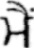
ਮੈਂ
